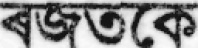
ৰজতকে
